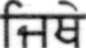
ਜਿਥੇ
